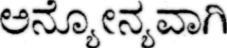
ಅನ್ಯೋನ್ಯವಾಗಿ
